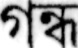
গন্ধ
